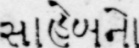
સાહેબનો
